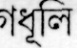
গধূলি
